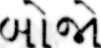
બોજો
